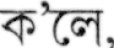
ক'লে,
